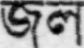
জল
